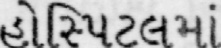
હોસ્પિટલમાં
